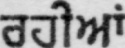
ਰਹੀਆਂ
